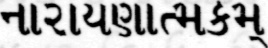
નારાયણાત્મકમ્
